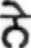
ਨੇ
